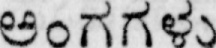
ಅಂಗಗಳು
